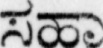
ಸಹಾ
